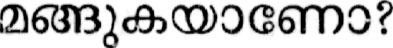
മങ്ങുകയാണോ?
